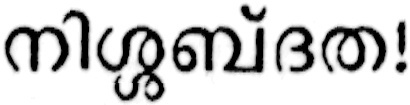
നിശ്ശബ്ദത!
